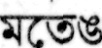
মতেঙ
